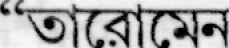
“তারোমেন
